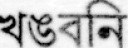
খঙবনি
